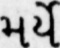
મર્યે
